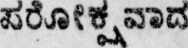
ಪರೋಕ್ಷವಾದ
